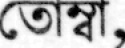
তোম্বা,
